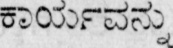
ಕಾರ್ಯವನ್ನು
